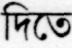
দিতে
